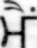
ਮੈਂ
